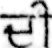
ਦੀ
